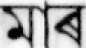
মাৰ
